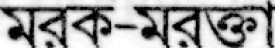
মরক-মরক্তা
